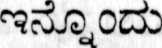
ಇನ್ನೊಂದು
